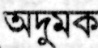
অদুমক
